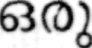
ഒരു
